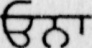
ਓਨਾ
